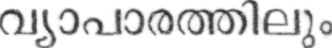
വ്യാപാരത്തിലും
